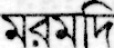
মরমদি
